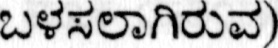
ಬಳಸಲಾಗಿರುವ)
